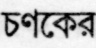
চণকের
